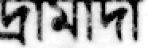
দ্রামাদা
